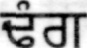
ਢੰਗ
